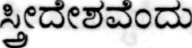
ಸ್ತ್ರೀದೇಶವೆಂದು
